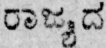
ರಾಜ್ಯದ
